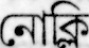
নোক্লি
